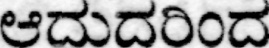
ಆದುದರಿಂದ
